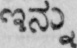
ಇನ್ನು
